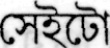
সেইটো
